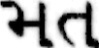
મત
